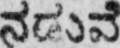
ನಡುವೆ
